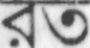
রত
